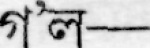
গ'ল-
